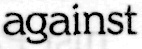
against
